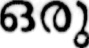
ഒരു
